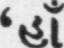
'હાઁ
